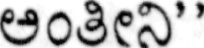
ಅಂತೀನಿ"
